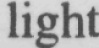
light
